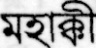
মহাক্কী
